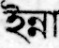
ইন্না
